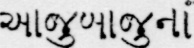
આજુબાજુનાં
